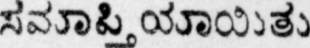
ಸಮಾಪ್ತಿಯಾಯಿತು
